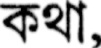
কথা,
